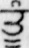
ਤੂੰ
